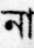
না
